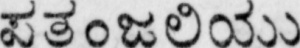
ಪತಂಜಲಿಯು
